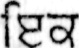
ਇਕ
